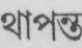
থাপন্ত
